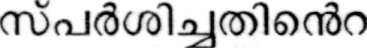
സ്പര്‍ശിച്ചതിന്റെ
